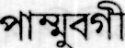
পাম্মুবগী
